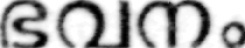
ഭവനം
